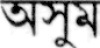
অসুম
